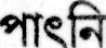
পাৎনি
